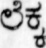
ಲೆಕ್ಕ
